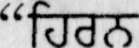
''ਹਿਰਨ
